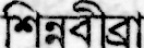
শিন্নবীব্রা
